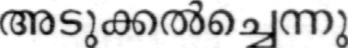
അടുക്കല്‍ച്ചെന്നു
